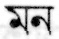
মন
